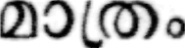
മാത്രം
